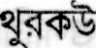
থুরকউ
